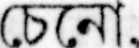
চেনো,
